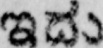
ಇದು
